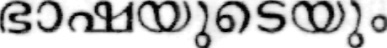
ഭാഷയുടെയും
